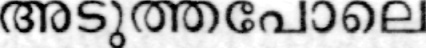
അടുത്തപോലെ
